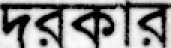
দরকার
